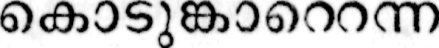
കൊടുങ്കാറ്റെന്ന
